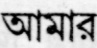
আমার
